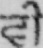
ਵੀ
